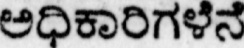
ಅಧಿಕಾರಿಗಳೆನೆ
